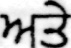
ਅਤੇ
